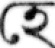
হে
